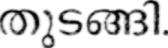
തുടങ്ങി.
